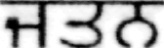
ਜਤਨ
